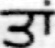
ਤਾਂ
